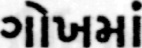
ગોખમાં
